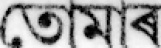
তোমাৰ
